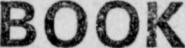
BOOK
